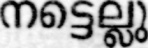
നട്ടെല്ലു
